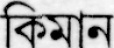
কিমান
